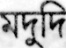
মদুদি
